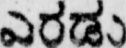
ಎರಡು
